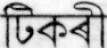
টিকৰী
